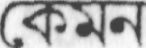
কেমন
